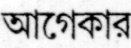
আগেকার
